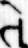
તે
